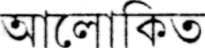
আলোকিত
